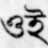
ওই
